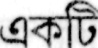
একটি
